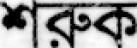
শরুক
